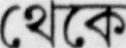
থেকে
